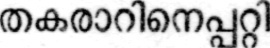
തകരാറിനെപ്പറ്റി
